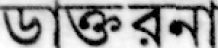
ডাক্তরনা
